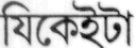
যিকেইটা
